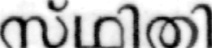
സ്ഥിതി
